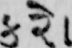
કરો
